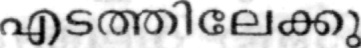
എടത്തിലേക്കു
